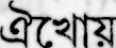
ঐখোয়
